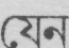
যেন
